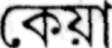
কেয়া
